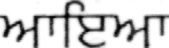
ਆਇਆ
